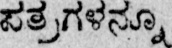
ಪ್ರತ್ರಗಳನ್ನೂ
